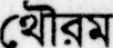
থৌরম
